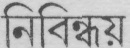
নিবিন্ধয়
